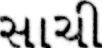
સાચી
